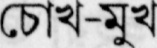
চোখ-মুখ
